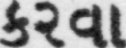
કરવા
